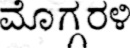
ಮೊಗ್ಗರಳಿ
